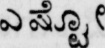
ಎಷ್ಟೋ
